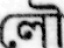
লৌ
